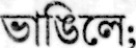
ভাঙিলে;
